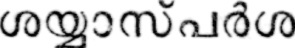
ശയ്യാസ്പര്‍ശ
